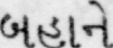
બહાને
